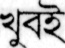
খুবই
